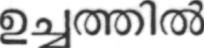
ഉച്ചത്തില്‍
